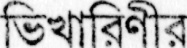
ভিখারিণীর
